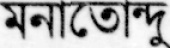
মনাতোন্দু
